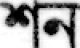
শন
